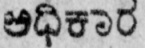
ಅಧಿಕಾರ
